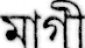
মাগী
